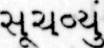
સૂચવ્યું
